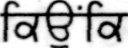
ਕਿਉਂਕਿ
